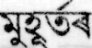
মুহূর্তৰ
